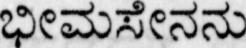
ಭೀಮಸೇನನು
